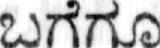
ಬಗೆಗೂ
